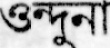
ওন্দুনা
